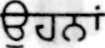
ਉਹਨਾਂ
